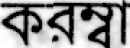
করম্বা
